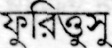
ফুরিত্তুসু
